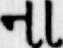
ના
